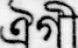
ঐগী
